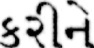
કરીને
